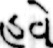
હવે
